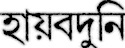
হায়বদুনি
